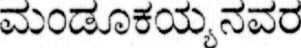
ಮಂಡೂಕಯ್ಯನವರ
